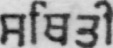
ਸਥਿਤੀ
